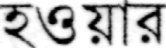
হওয়ার
